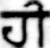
ਹੀ
